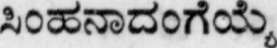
ಸಿಂಹನಾದಂಗೆಯ್ಯೆ
